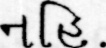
નહિ.
